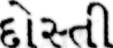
દોસ્તી
